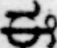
ಈ
